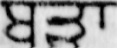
ਬੜਾ
